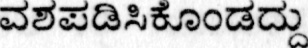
ವಶಪಡಿಸಿಕೊಂಡದ್ದು
